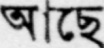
আছে
